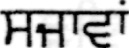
ਸਜਾਵਾਂ
